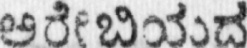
ಅರೇಬಿಯದ
